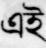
এই
